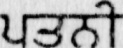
ਪਤਨੀ
